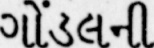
ગોંડલની
